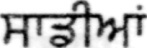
ਸਾਡੀਆਂ
